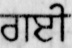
ਗਈ
